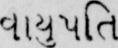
વાયુપતિ
